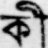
কী
